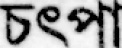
চৎপা
